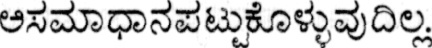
ಅಸಮಾಧಾನಪಟ್ಟುಕೊಳ್ಳುವುದಿಲ್ಲ.
